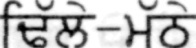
ਢਿੱਲੇ-ਮੱਠੇ
